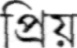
প্রিয়
